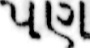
પણ
